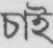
চাই
